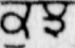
ਕੁਝ
